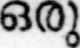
ഒരു
